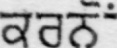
ਕਰਨੋਂ
